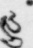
હું
